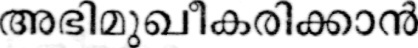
അഭിമുഖീകരിക്കാന്‍
